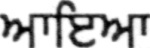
ਆਇਆ
